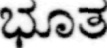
ಭೂತ
